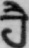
ਹੈ
